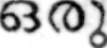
ഒരു
